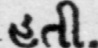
હતી.
